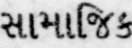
સામાજિક
